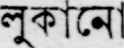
লুকানো
